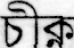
চীক্ন
